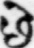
છે
